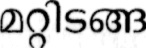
മറ്റിടങ്ങ
